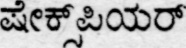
ಷೇಕ್ಸ್‌ಪಿಯರ್
